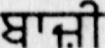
ਬਾਜ਼ੀ
